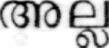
അല്ല
